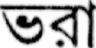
ভরা
